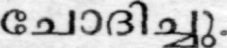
ചോദിച്ചു.
